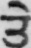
ਤੇ
